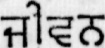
ਜੀਵਨ
